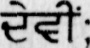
ਦੇਵੀਂ;
